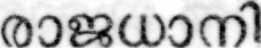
രാജധാനി
